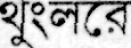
থুংলরে
